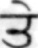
ਤੇ
